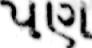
પણ
